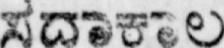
ಸದಾಕಾಲ
